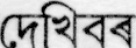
দেখিবৰ
